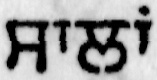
ਸਾਲਾਂ
